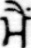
ਮੈਂ
